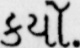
કર્યો.
